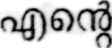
എന്റെ
